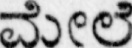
ಮೇಲೆ
